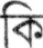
কি
